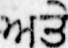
ਅਤੇ
